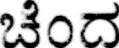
ಚೆಂದ
